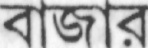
বাজার
